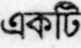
একটি
